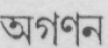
অগণন
